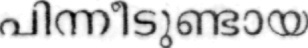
പിന്നീടുണ്ടായ
